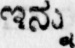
ಇನ್ನು
